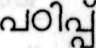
പഠിപ്പ്
